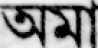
অমা
